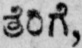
ತೆರಿಗೆ,
